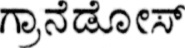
ಗ್ರಾನೆಡೋಸ್
